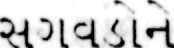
સગવડોને
